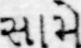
સામે
